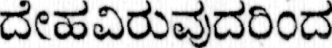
ದೇಹವಿರುವುದರಿಂದ
